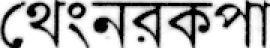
থেংনরকপা
